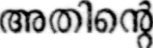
അതിന്റെ
